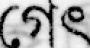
গেৎ
